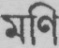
মণি
